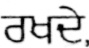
ਰਖਦੇ,
